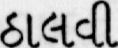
ઠાલવી
